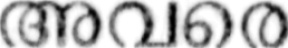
അവരെ
